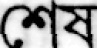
শেষ
